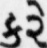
કરે
